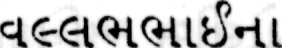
વલ્લભભાઈના
